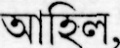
আহিল,
